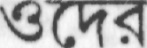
ওদের
